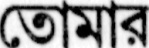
তোমার
